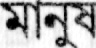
মানুষ
